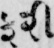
ફરી
